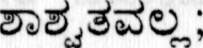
ಶಾಶ್ವತವಲ್ಲ;
